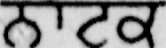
ਨਾਟਕ
